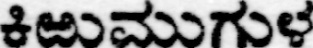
ಕಿಱುಮುಗುಳ
